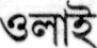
ওলাই
